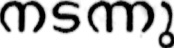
നടന്നു
